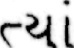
ત્યાં
